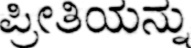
ಪ್ರೀತಿಯನ್ನು
